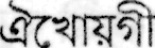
ঐখোয়গী
